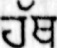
ਹੱਥ
